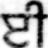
ਈ
